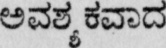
ಅವಶ್ಯಕವಾದ
